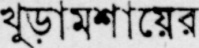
খুড়ামশায়ের
